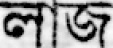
লাজ
